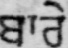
ਬਾਰੇ
